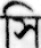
সি
